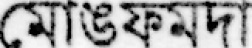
মোঙফমদা
